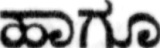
ಹಾಗೂ
